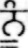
ਨੂੰ
